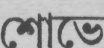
শোভে
